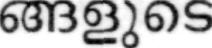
ങ്ങളുടെ
